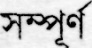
সম্পূর্ণ
